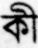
কী
